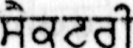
ਸੈਕਟਰੀ
